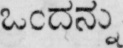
ಒಂದನ್ನು
